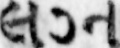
લગ્ન
